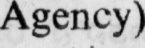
Agency
